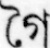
গৈ
